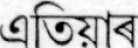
এতিয়াৰ
